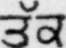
ਤੱਕ
